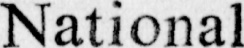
National
